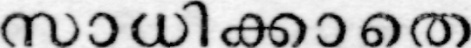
സാധിക്കാതെ
